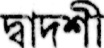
দ্বাদশী
